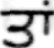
ਤਾਂ
